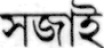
সজাই
